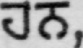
ਹਨ,
